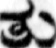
ತು
